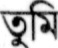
তুমি
